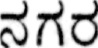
ನಗರ
